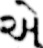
એ
